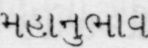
મહાનુભાવ
